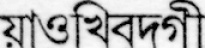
য়াওখিবদগী
